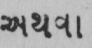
અથવા
